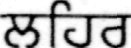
ਲਹਿਰ
